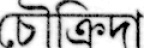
চৌক্রিদা
